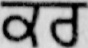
ਕਰ
